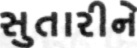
સુતારીને
